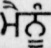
ਮੈਨੂੰ
